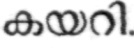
കയറി.
